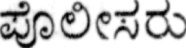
ಪೊಲೀಸರು
